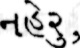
નેહરુ,
